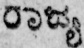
ರಾಜ್ಯ
